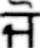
ਜੋ
